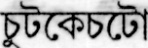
চুটকেচটো
